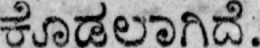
ಕೊಡಲಾಗಿದೆ.
